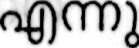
എന്നു
